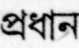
প্রধান
